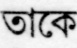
তাকে
